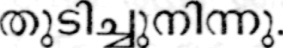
തുടിച്ചുനിന്നു.
